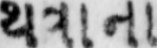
થવાના
